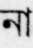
না
